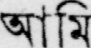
আমি
